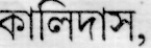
কালিদাস,
